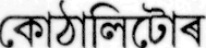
কোঠালিটোৰ
